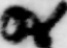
જ
